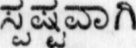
ಸ್ಪಷ್ಟವಾಗಿ
